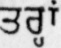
ਤਰ੍ਹਾਂ
